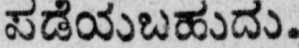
ಪಡೆಯಬಹುದು.
